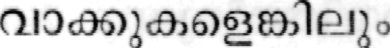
വാക്കുകളെങ്കിലും
